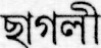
ছাগলী
